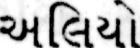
અલિયો
